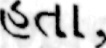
હતા,
